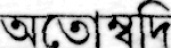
অতোম্বদি
